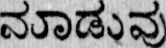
ಮಾಡುವು
